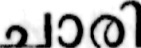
ചാരി
